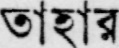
তাহার
